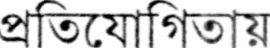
প্রতিযোগিতায়
